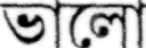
ভালো
